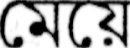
মেয়ে
